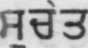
ਸੁਚੇਤ
